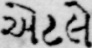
એટલે
